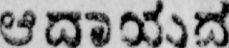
ಆದಾಯದ
